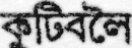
কুটিবলৈ
